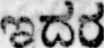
ಇದರ
